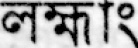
লহ্মাং
